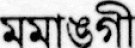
মমাঙগী
